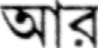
আর
